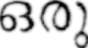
ഒരു
